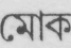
মোক
